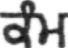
ਕੰਮ
